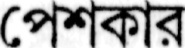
পেশকার
